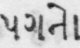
પગનો
